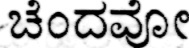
ಚೆಂದವೋ
